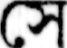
সে
